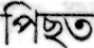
পিছত
